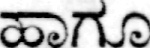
ಹಾಗೂ
